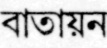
বাতায়ন
